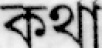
কথা
